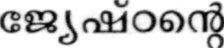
ജ്യേഷ്ഠന്റെ
